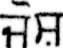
ਜੋਸ਼
